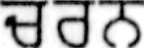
ਚਰਨ
